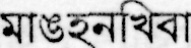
মাঙহনখিবা
